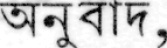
অনুবাদ,
